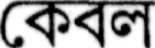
কেবল
